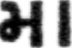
મા
